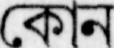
কোন
